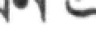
যেন
